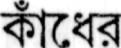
কাঁধের
